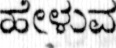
ಹೇಳುವ
